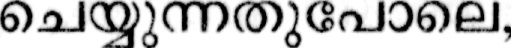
ചെയ്യുന്നതുപോലെ,
